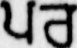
ਪਰ
